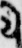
યે
